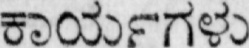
ಕಾರ್ಯಗಳು
